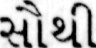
સૌથી
